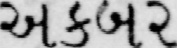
અકબર
